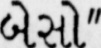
બેસો"
